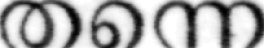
തന്നെ
